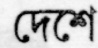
দেশে
